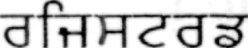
ਰਜਿਸਟਰਡ
